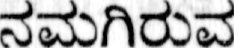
ನಮಗಿರುವ
